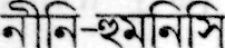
নীনি-হুমনিসি
